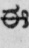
ಈ
